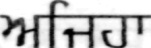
ਅਜਿਹਾ
